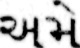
અમે
